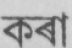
কৰা
